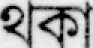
থকা
